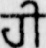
ਹੀ
